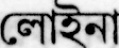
লোইনা
